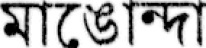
মাঙোন্দা
